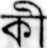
কী
